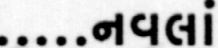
......નવલાં
